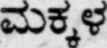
ಮಕ್ಕಳ
